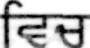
ਵਿਚ
